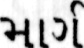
માર્ગ
